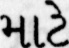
માટે
